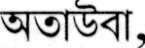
অতাউবা,
